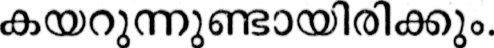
കയറുന്നുണ്ടായിരിക്കും.
